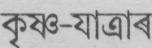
কৃষ্ণ-যাত্ৰাৰ
